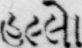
હલ્લો
